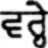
ਵਰ੍ਹੇ
